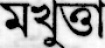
মখুত্তা
